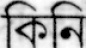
কিনি
